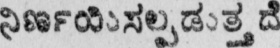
ನಿರ್ಣಯಿಸಲ್ಪಡುತ್ತದೆ.
